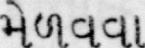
મેળવવા
